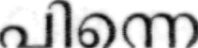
പിന്നെ
